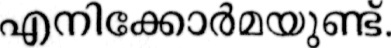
എനിക്കോര്‍മയുണ്ട്.
